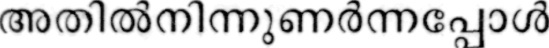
അതില്‍നിന്നുണര്‍ന്നപ്പോള്‍
